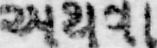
અથવા
